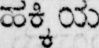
ಹಕ್ಕಿಯ
